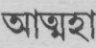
আত্মহা
